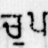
ਚੁਪ
